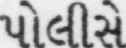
પોલીસે
